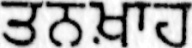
ਤਨਖ਼ਾਹ
